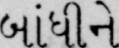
બાંધીને
